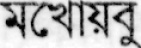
মখোয়বু
